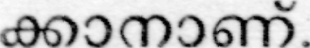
ക്കാനാണ്.
